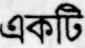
একটি
